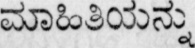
ಮಾಹಿತಿಯನ್ನು
